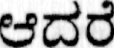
ಆದರೆ
